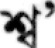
শ্ব'
